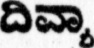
ದಿವ್ಯಾ
